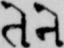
તેને
